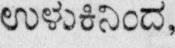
ಉಳುಕಿನಿಂದ,
